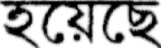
হয়েছে
